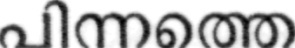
പിന്നത്തെ
